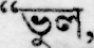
"ভুল,
